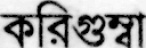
করিগুম্বা
